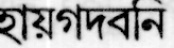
হায়গদবনি
